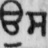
ਉਸ
